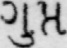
ગુપ્ત
